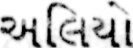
અલિયો
